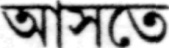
আসতে
